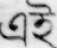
এই
